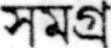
সমগ্র
